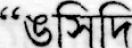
“ঙসিদি
